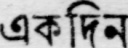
একদিন
